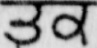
ਤਕ
